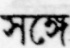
সঙ্গে
